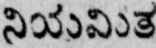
ನಿಯಮಿತ
